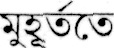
মুহূর্ততে
